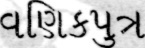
વણિકપુત્ર
